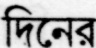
দিনের
